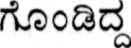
ಗೊಂಡಿದ್ದ
